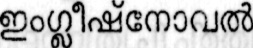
ഇംഗ്ലീഷ്നോവല്‍
